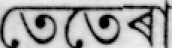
তেতেৰা
